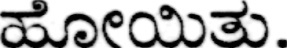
ಹೋಯಿತು.
